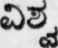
ವಿಶ್ವ
